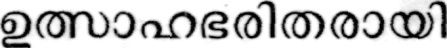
ഉത്സാഹഭരിതരായി
